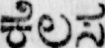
ಕೆಲಸ
